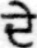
ਦੇ
